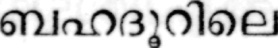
ബഹദൂറിലെ
